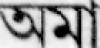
অমা
